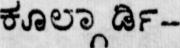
ಕೂಲ್ಗಾರ್ಡಿ-
